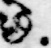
છે.
